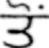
ਤੋਂ
